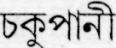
চকুপানী
